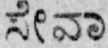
ಸೇವಾ
